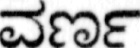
ವರ್ಣ
